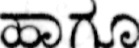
ಹಾಗೂ
